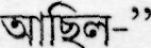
আছিল-"
